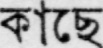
কাছে
